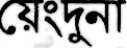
য়েংদুনা
